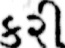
કરી
